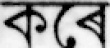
কৰে
